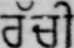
ਰੱਚੀ
